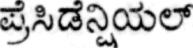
ಪ್ರೆಸಿಡೆನ್ಷಿಯಲ್
